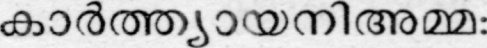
കാര്‍ത്ത്യായനിഅമ്മ:
